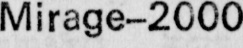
Mirage-2000
